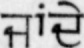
ਜਾਂਦੇ
